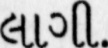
લાગી.
